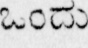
ಒಂದು
